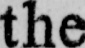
the
